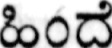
ಹಿಂದೆ
